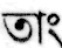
তাং
